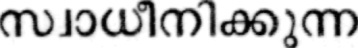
സ്വാധീനിക്കുന്ന
